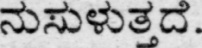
ನುಸುಳುತ್ತದೆ.
